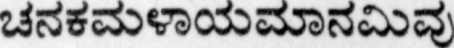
ಚನಕಮಳಾಯಮಾನಮಿವು
